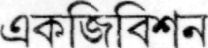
একজিবিশন
